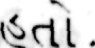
હતો.
